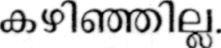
കഴിഞ്ഞില്ല.
